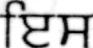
ਇਸ
